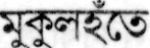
মুকুলহঁতে
